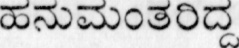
ಹನುಮಂತರಿದ್ದ
